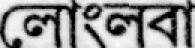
লোংলবা
